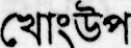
খোংউপ
